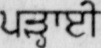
ਪੜ੍ਹਾਈ
